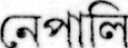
নেপালি
